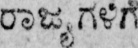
ರಾಜ್ಯಗಳಿಗೆ
